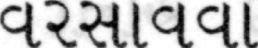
વરસાવવા
